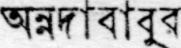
অন্নদাবাবুর
